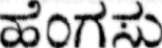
ಹೆಂಗಸು
